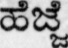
ಹೆಜ್ಜೆ
